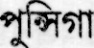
পুন্সিগা
